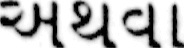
અથવા
